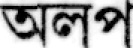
অলপ
